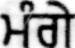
ਮੰਗੇ
